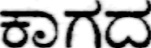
ಕಾಗದ
